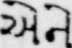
એને
